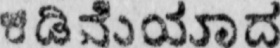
ಕಡಿಮೆಯಾದ
